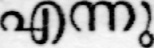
എന്നു
